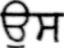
ਉਸ
